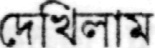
দেখিলাম
